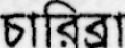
চারিব্রা
